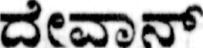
ದೇವಾನ್
